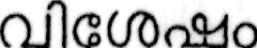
വിശേഷം
